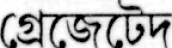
গ্রেজেটেদ
